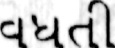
વધતી
